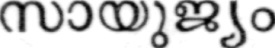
സായുജ്യം
